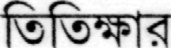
তিতিক্ষার
